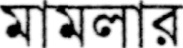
মামলার
